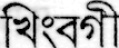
খিংবগী
